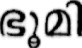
ഭൂമി
